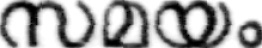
സമയം
